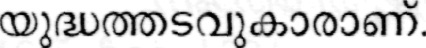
യുദ്ധത്തടവുകാരാണ്.
